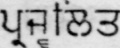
ਪ੍ਰਜ੍ਵਲਿਤ
